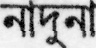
নাদুনা
